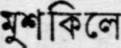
মুশকিলে
